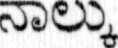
ನಾಲ್ಕು
